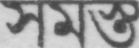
সমস্ত
